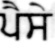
ਪੈਸੇ
